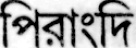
পিরাংদি
